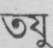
তযু
